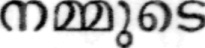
നമ്മുടെ
